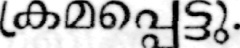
ക്രമപ്പെട്ടു.
